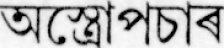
অস্ত্রোপচাৰ
